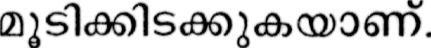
മൂടിക്കിടക്കുകയാണ്.
